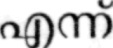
എന്ന്
